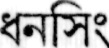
ধনসিং
